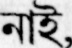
নাই,
